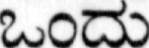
ಒಂದು
